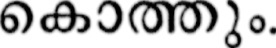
കൊത്തും.
